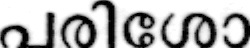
പരിശോ
